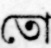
তো
